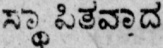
ಸ್ಥಾಪಿತವಾದ
